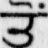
ਤੋਂ
